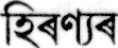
হিৰণ্যৰ
